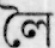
লৈ
